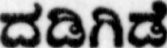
ದಡಿಗಿಡೆ
